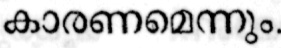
കാരണമെന്നും,
